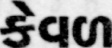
કેવળ
